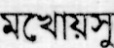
মখোয়সু
